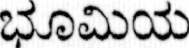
ಭೂಮಿಯ
